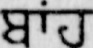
ਬਾਂਹ
